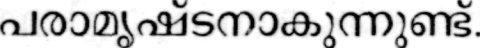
പരാമൃഷ്ടനാകുന്നുണ്ട്.
